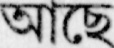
আছে
